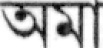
অমা
